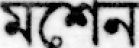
মশেন
